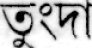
তুংদা
